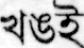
খঙই
